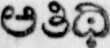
ಅತಿಥಿ
